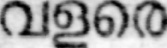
വളരെ
